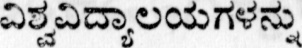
ವಿಶ್ವವಿದ್ಯಾಲಯಗಳನ್ನು
